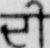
ਦੀ
